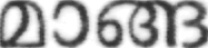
മാങ്ങ
